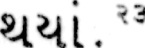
થયાં.૨૩
